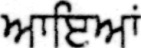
ਆਇਆ
